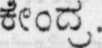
ಕೇಂದ್ರ.
